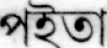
পইতা
